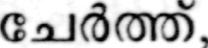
ചേര്‍ത്ത്,
